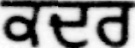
ਕਦਰ
